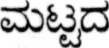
ಮಟ್ಟದ
